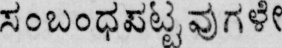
ಸಂಬಂಧಪಟ್ಟವುಗಳೇ
